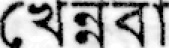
খেন্নবা
